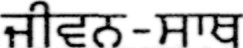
ਜੀਵਨ-ਸਾਥ
